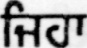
ਜਿਹਾ
